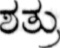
ಶತ್ರು
